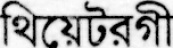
থিয়েটরগী
